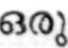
ഒരു
